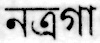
নত্রগা
